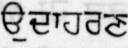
ਉਦਾਹਰਣ
